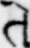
તે
